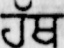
ਹੱਥ
